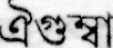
ঐগুম্বা
